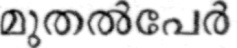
മുതല്‍പേര്‍
